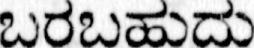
ಬರಬಹುದು
